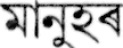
মানুহৰ
